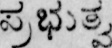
ಪ್ರಭುತ್ವ
